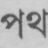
পথ
